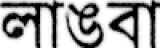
লাঙবা
